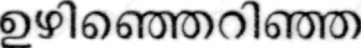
ഉഴിഞ്ഞെറിഞ്ഞ
